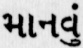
માનવું
